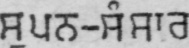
ਸੁਪਨ-ਸੰਸਾਰ
